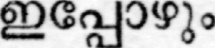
ഇപ്പോഴും
